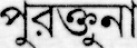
পুরক্তুনা
